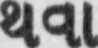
થવા
